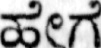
ಹೇಗೆ
